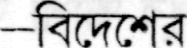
-বিদেশের
